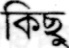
কিছু
